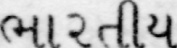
ભારતીય
